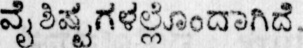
ವೈಶಿಷ್ಟಗಳಲ್ಲೊಂದಾಗಿದೆ.
